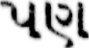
પણ
